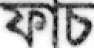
ফাচ
